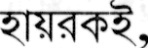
হায়রকই,
